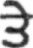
ਤੇ
